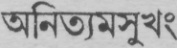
অনিত্যমসুখং
